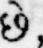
છે,
